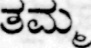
ತಮ್ಮ
